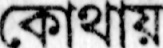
কোথায়
